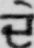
ਦੇ
